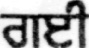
ਗਈ
